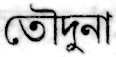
তৌদুনা
